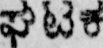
ಘಟಕ
